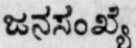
ಜನಸಂಖ್ಯೆ
